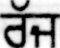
ਰੱਜ
